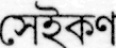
সেইকণ
